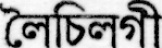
লৈচিলগী
